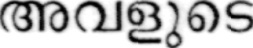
അവളുടെ
